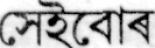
সেইবোৰ
